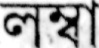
লম্বা
